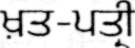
ਖ਼ਤ-ਪਤ੍ਰੀ
